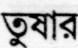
তুষার
